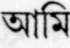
আমি
